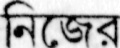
নিজের
